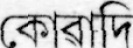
কোৱাদি
